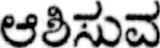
ಆಶಿಸುವ
